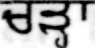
ਚੜ੍ਹਾ
